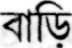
বাড়ি
